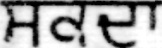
ਸਕਦਾ
